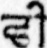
ਵੀ
